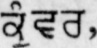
ਕੁੰਵਰ,
